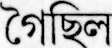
গৈছিল
